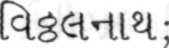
વિઠ્ઠલનાથ;
